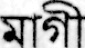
মাগী
